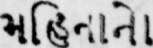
મહિનાનો
